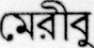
মেরীবু
